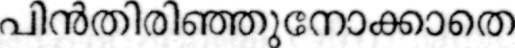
പിന്‍തിരിഞ്ഞുനോക്കാതെ
